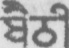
ਬੈਠੀ
